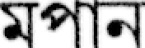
মপান
